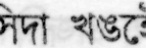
লৈরখিনি,
